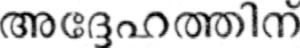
അദ്ദേഹത്തിന്
